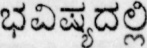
ಭವಿಷ್ಯದಲ್ಲಿ
